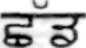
ਛੱਡ
